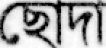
ছোদা
